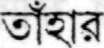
তাঁহার
